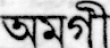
অমগী
